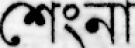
শেংনা
